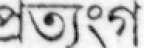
প্ৰত্যংগ
